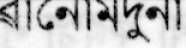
ৱানোমদুনা
